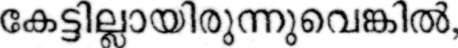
കേട്ടില്ലായിരുന്നുവെങ്കില്‍,
